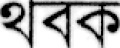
থবক
